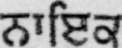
ਨਾਇਕ
